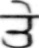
ਤੇ
